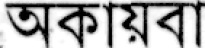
অকায়বা
